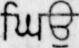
ਘਿਉ
